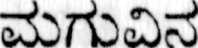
ಮಗುವಿನ
